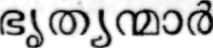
ഭൃത്യന്മാര്‍
